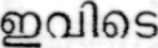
ഇവിടെ
